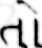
તો
